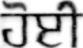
ਹੋਈ
